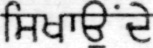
ਸਿਖਾਉਂਦੇ
